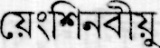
য়েংশিনবীয়ু
